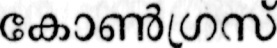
കോണ്‍ഗ്രസ്
